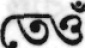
তেওঁ
